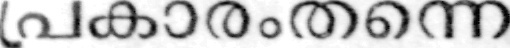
പ്രകാരംതന്നെ
